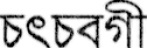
চৎচবগী
